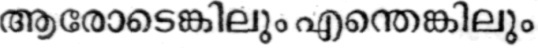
ആരോടെങ്കിലുംഎന്തെങ്കിലും
